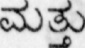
ಮತ್ತು
